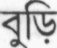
বুড়ি
